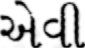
એવી
